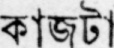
কাজটা
